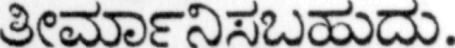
ತೀರ್ಮಾನಿಸಬಹುದು.
